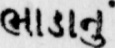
ભાડાનું
